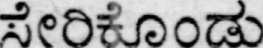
ಸೇರಿಕೊಂಡು
